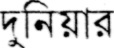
দুনিয়ার
